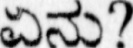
ಏನು?
